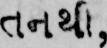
તનથી,
